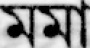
মমা
